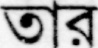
তার
